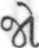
જો
